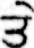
ਤੇ
